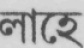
লাহে
